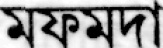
মফমদা
